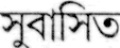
সুবাসিত
